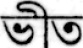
ভীত
